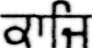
ਕਾਜਿ
